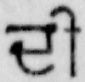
ਦੀ
